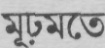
মূঢ়মতে
